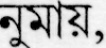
নুমায়,
